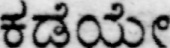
ಕಡೆಯೇ
